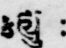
કહ્યુંઃ
